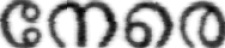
നേരെ
